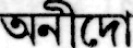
অনীদো
